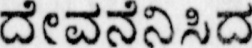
ದೇವನೆನಿಸಿದ
